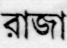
রাজা
